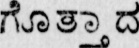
ಗೊತ್ತಾದ
